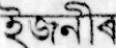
ইজনীৰ
